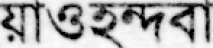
য়াওহন্দবা
